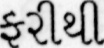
ફરીથી
